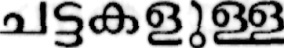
ചട്ടകളുള്ള
